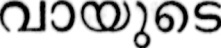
വായുടെ
